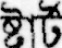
ষ্টার্ট
